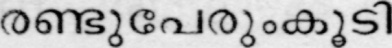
രണ്ടുപേരുംകൂടി
